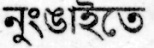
নুংঙাইতে
